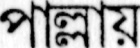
পাল্লায়
